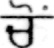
ਚੋਂ
